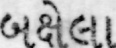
બક્ષેલા
